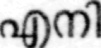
എനി
